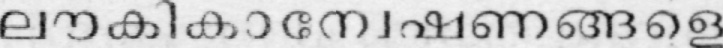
ലൌകികാന്വേഷണങ്ങളെ
